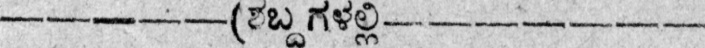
-------(ಶಬ್ದಗಳಲ್ಲಿ--------
